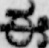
ಈ
